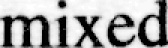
mixed
